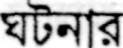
ঘটনার
